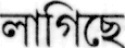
লাগিছে
